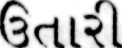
ઉતારી
